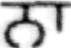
ਨਾ
